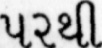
પરથી
